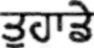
ਤੁਹਾਡੇ
